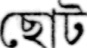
ছোট
